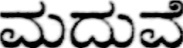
ಮದುವೆ
